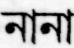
নানা
